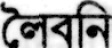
লৈবনি
